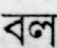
বল
